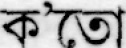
ক'তো
